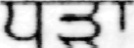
ਧੜਾ
